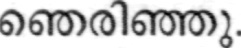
ഞെരിഞ്ഞു.
